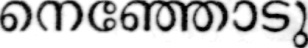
നെഞ്ഞോടു
